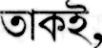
তাকই,
